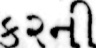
કરની
